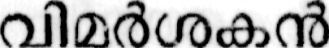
വിമര്‍ശകന്‍
